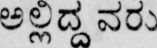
ಅಲ್ಲಿದ್ದವರು
